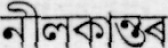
নীলকান্তৰ
